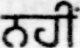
ਨਹੀਂ
